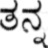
ತನ್ನ
